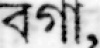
বগা,
